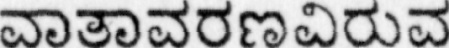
ವಾತಾವರಣವಿರುವ
